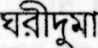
ঘরীদুমা
